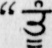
''ਤੂੰ
